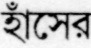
হাঁসের
